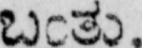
ಬಂತು.
